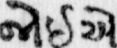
જોઈએ
